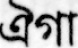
ঐগা
